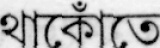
থাকোঁতে
